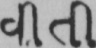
વીતી
